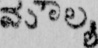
ಮೌಲ್ಯ
